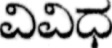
ವಿವಿಧ
